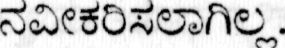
ನವೀಕರಿಸಲಾಗಿಲ್ಲ.
